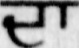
ਦਾ
